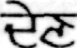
ਦੇਣ
